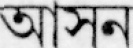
আসন
